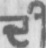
ਦੀ
